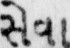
સેવા
